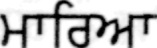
ਮਾਰਿਆ
